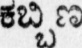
ಕಬ್ಬಿಣ
